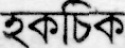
হকচিক
